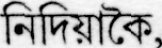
নিদিয়াকৈ,
